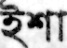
ইশা
